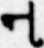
ન
